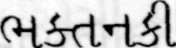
ભક્તનકી
